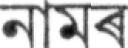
নামৰ
